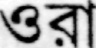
ওরা
